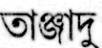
তাঞ্জাদু
